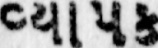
વ્યાપક
